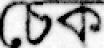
চেক
